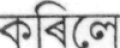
কৰিলে
